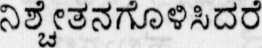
ನಿಶ್ಚೇತನಗೊಳಿಸಿದರೆ
